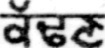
ਕੱਢਣ
